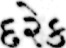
દરેક
